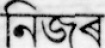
নিজৰ
